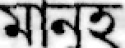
মানহ
